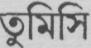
তুমিসি
